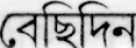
বেছিদিন
